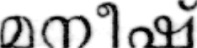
മനീഷ്
